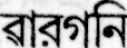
ৱারগনি
